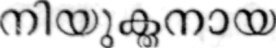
നിയുക്തനായ
